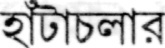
হাঁটাচলার
